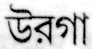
উরগা
